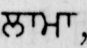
ਲਾਮਾ,
